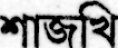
শাজখি
